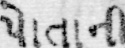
પોતાની
